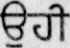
ਉਹੀ
